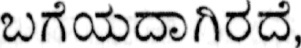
ಬಗೆಯದಾಗಿರದೆ,
